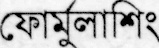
ফোর্মুলাশিং
